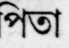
পিতা
